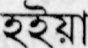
হইয়া
